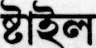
ষ্টাইল
